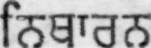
ਨਿਥਾਰਨ
